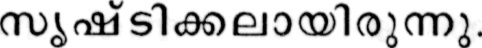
സൃഷ്ടിക്കലായിരുന്നു.
